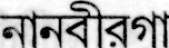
নানবীরগা
